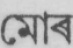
মোৰ
